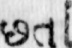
છતાં
